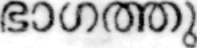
ഭാഗത്തു
